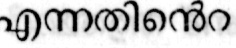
എന്നതിന്റെ
